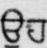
ਉਹ
